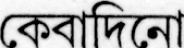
কেবাদিনো
